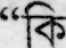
"কি
